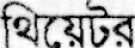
থিয়েটর
